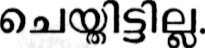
ചെയ്തിട്ടില്ല.
